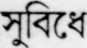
সুবিধে
